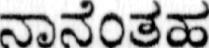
ನಾನೆಂತಹ
